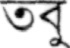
তবু
